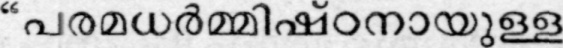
"പരമധര്‍മ്മിഷ്ഠനായുള്ള
